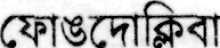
ফোঙদোক্লিবা
